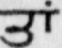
ਤਾਂ
